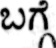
ಬಗ್ಗೆ
